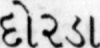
દોરડા
